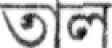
তাল
